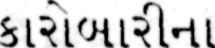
કારોબારીના
